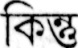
কিন্তু
